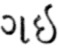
ગઈ
